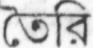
তৈরি
